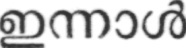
ഇന്നാള്‍
